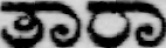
ತಾರಾ
